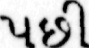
પછી
